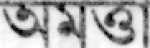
অমত্তা
